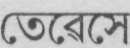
তেৱেসে
